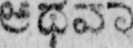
ಅಥವಾ
